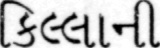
કિલ્લાની
